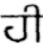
ਹੀ
